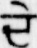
ਦੇ
